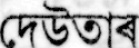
দেউতাৰ
